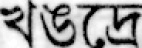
খঙদ্রে
